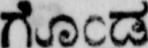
ಗೊಂಡ
